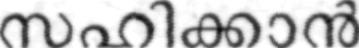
സഹിക്കാന്‍
